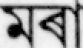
মৰা
